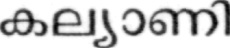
കല്യാണി
